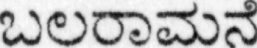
ಬಲರಾಮನೆ
